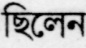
ছিলেন
